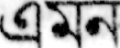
এমন
